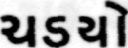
ચડ્યો
